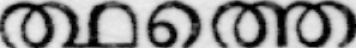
ത്ഥത്തെ
